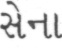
સેના
